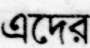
এদের
